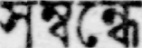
সম্বন্ধে
